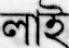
লাই
